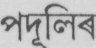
পদূলিৰ
